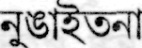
নুঙাইতনা
